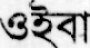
ওইবা
